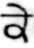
ਕੇ
